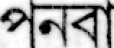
পনবা
